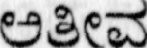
ಅತೀವ
